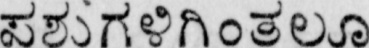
ಪಶುಗಳಿಗಿಂತಲೂ
